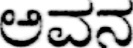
ಅವನ
